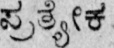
ಪ್ರತ್ಯೇಕ
